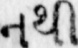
નથી
